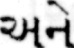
અને
